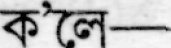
ক'লে-
